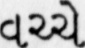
વચ્ચે
